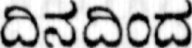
ದಿನದಿಂದ
